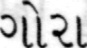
ગોરા
